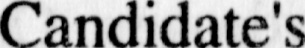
Candidate’s
